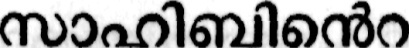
സാഹിബിന്റെ
